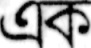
এক
